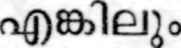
എങ്കിലും
